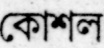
কোশল
